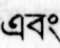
এবং
